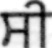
ਸੀ
